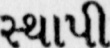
સ્થાપી
